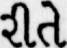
રીતે
